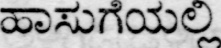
ಹಾಸುಗೆಯಲ್ಲಿ
